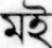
মই
